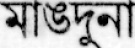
মাঙদুনা
